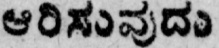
ಆರಿಸುವುದು
